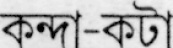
কন্দা-কটা
